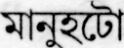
মানুহটো
